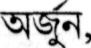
অর্জুন,
